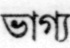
ভাগ্য
